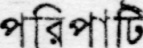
পরিপাটি
